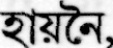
হায়নৈ,
